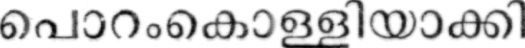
പൊറംകൊള്ളിയാക്കി
